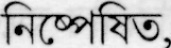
নিষ্পেষিত,
